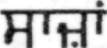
ਸਾਜ਼ਾਂ
